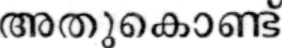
അതുകൊണ്ട്
